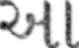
આ
